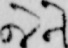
જેને
